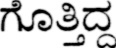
ಗೊತ್ತಿದ್ದ
